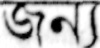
জন্য
